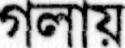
গলায়
